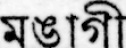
মঙাগী
